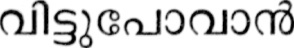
വിട്ടുപോവാന്‍
